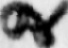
જ
